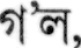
গ'ল,
